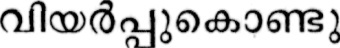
വിയര്‍പ്പുകൊണ്ടു
